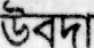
উবদা
